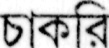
চাকরি
